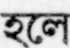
হলে
